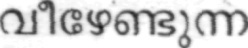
വീഴേണ്ടുന്ന
